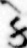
કે
